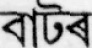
বাটৰ
